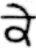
ਕੇ
